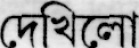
দেখিলো
